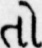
તો
